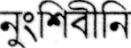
নুংশিবীনি
